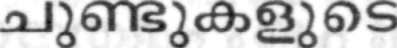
ചുണ്ടുകളുടെ
